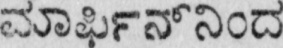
ಮಾರ್ಫಿನ್‌ನಿಂದ
